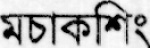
মচাকশিং
